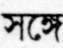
সঙ্গে
